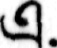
এ.
